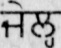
ਜੇਲ੍ਹ
